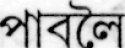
পাবলৈ
